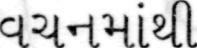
વચનમાંથી
